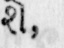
શે,
